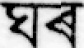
ঘৰ
